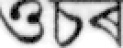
ওচৰ
